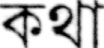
কথা
